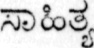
ಸಾಹಿತ್ಯ
